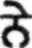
ਨੇ
